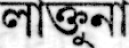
লাক্তুনা
